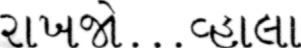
રાખજો...વ્હાલા
